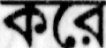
করে
